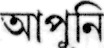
আপুনি
